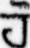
ਹੋ
